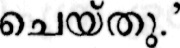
ചെയ്തു.’
